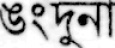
ঙংদুনা
